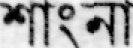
শাংনা
